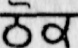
ਠੋਕ
